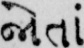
જોતાં
